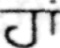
ਹਾਂ
